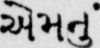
એમનું
